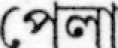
পেলা
